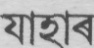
যাহাৰ
